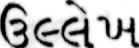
ઉલ્લેખ
